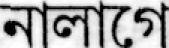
নালাগে
